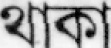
থাকা
